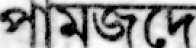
পামজদে
